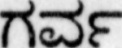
ಗರ್ವ
